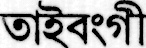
তাইবংগী
